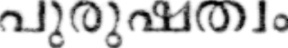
പുരുഷത്വം
